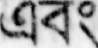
এবং
